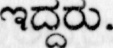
ಇದ್ದರು.
